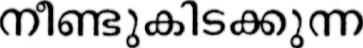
നീണ്ടുകിടക്കുന്ന
